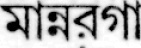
মান্নরগা
